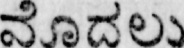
ಮೊದಲು
